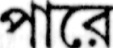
পারে
